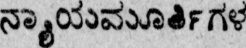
ನ್ಯಾಯಮೂರ್ತಿಗಳ
